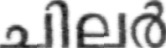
ചിലര്‍
